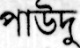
পাউদু
